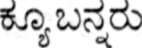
ಕ್ಯೂಬನ್ನರು
